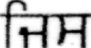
ਜਿਸ
